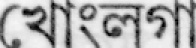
খোংলগা
